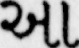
આ
